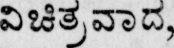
ವಿಚಿತ್ರವಾದ,
